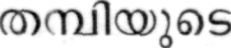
തമ്പിയുടെ
